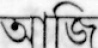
আজি
